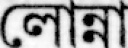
লোন্না
